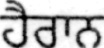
ਹੈਰਾਨ
